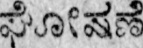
ಘೋಷಣೆ
